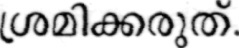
ശ്രമിക്കരുത്.
